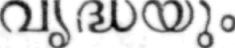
വൃദ്ധയും
